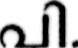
പി.
